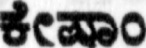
ಕೇಷಾಂ
